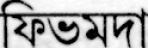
ফিভমদা
